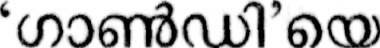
‘ഗാണ്‍ഡി’യെ
